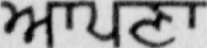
ਆਪਣਾ
